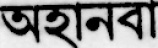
অহানবা
